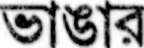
ভাঙার
